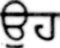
ਉਹ
